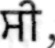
ਸੀ,
